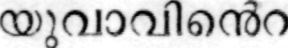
യുവാവിന്റെ
